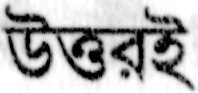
উত্তরই
